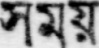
সময়
